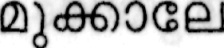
മുക്കാലേ
